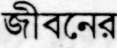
জীবনের
